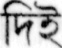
দিই
